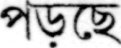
পড়ছে
